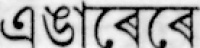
এঙাৰেৰে
